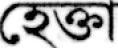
হেক্তা
